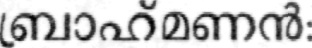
ബ്രാഹ്മണന്‍:
